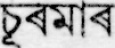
চূৰমাৰ
